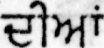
ਦੀਆਂ
